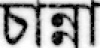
চান্না
